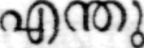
എന്തു
